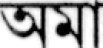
অমা
